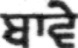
ਬਾਵੇ
